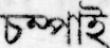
চম্পাই
